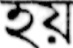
হয়
